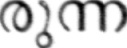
രുന്ന
